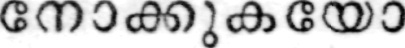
നോക്കുകയോ
